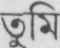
তুমি
